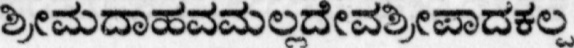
ಶ್ರೀಮದಾಹವಮಲ್ಲದೇವಶ್ರೀಪಾದಕಲ್ಲ
